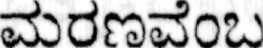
ಮರಣವೆಂಬ
